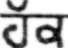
ਹੱਕ
